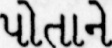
પોતાને
